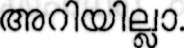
അറിയില്ലാ.
